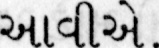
આવીએ.
